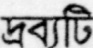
দ্রব্যটি
